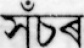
সঁচৰ
